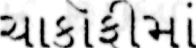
ચાકૉફીમાં
